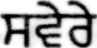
ਸਵੇਰੇ
